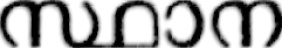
സ്ഥാന
